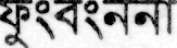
ফুংবংননা
